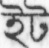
ইট
